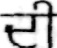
ਦੀ
